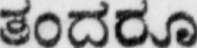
ತಂದರೂ
